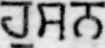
ਹੁਸਨ
